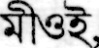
মীওই,
